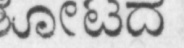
ತೋಟದ
